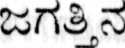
ಜಗತ್ತಿನ
